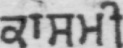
ਕਾਸਮੀ
